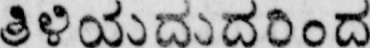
ತಿಳಿಯದುದರಿಂದ
